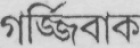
গৰ্জ্জিবাক
